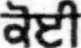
ਕੋਈ
